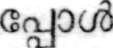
പ്പോള്‍
